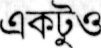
একটুও
